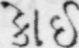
કોઈ
